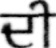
ਦੀ
